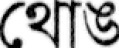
থোঙ
